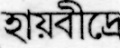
হায়বীদ্রে
